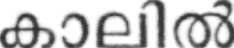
കാലില്‍
